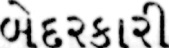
બેદરકારી
